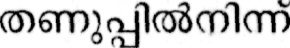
തണുപ്പില്‍നിന്ന്
